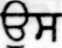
ਉਸ
